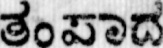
ತಂಪಾದ
